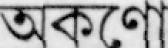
অকণো
